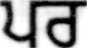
ਪਰ
